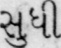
સુધી
